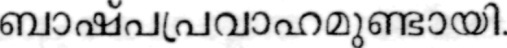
ബാഷ്പപ്രവാഹമുണ്ടായി.
